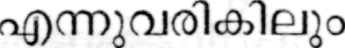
എന്നുവരികിലും
